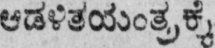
ಆಡಳಿತಯಂತ್ರಕ್ಕೆ
